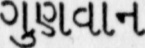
ગુણવાન
